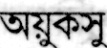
অয়ুকসু
